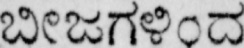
ಬೀಜಗಳಿಂದ
